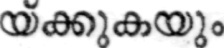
യ്ക്കുകയും
